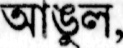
আঙুল,
